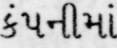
કંપનીમાં
